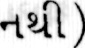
નથી)
